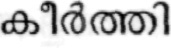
കീര്‍ത്തി
